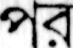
পর
